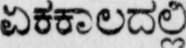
ಏಕಕಾಲದಲ್ಲಿ
